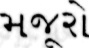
મજૂરો
